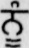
ਨੂੰ
